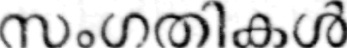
സംഗതികള്‍
